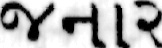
જનાર
